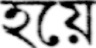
হয়ে
